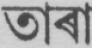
তাৰা
